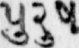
પુરુષ
